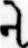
ને
